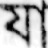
যা
